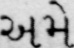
અમે
